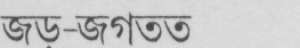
জড়-জগতত
